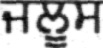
ਜਲੂਸ
